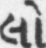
લો
